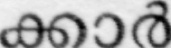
ക്കാര്‍
